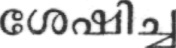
ശേഷിച്ച
